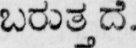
ಬರುತ್ತದೆ.
